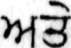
ਅਤੇ
